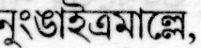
নুংঙাইত্রমাল্লে,
